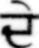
ਦੇ
